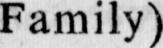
Family)
